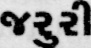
જરુરી
